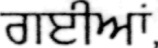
ਗਈਆਂ,
